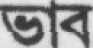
ভাব
